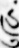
હું
